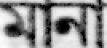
মানা
